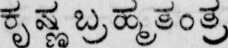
ಕೃಷ್ಣಬ್ರಹ್ಮತಂತ್ರ
